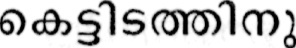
കെട്ടിടത്തിനു
